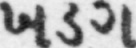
ખડગ
